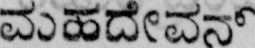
ಮಹದೇವನ್
